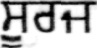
ਸੂਰਜ
